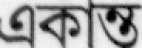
একান্ত
